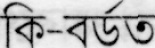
কি-বর্ডত
